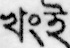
খংই
